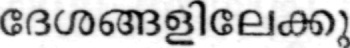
ദേശങ്ങളിലേക്കു
